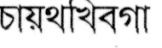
চায়থখিবগা
